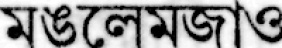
মঙলেমজাও
